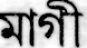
মাগী
